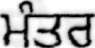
ਮੰਤਰ
